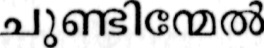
ചുണ്ടിന്മേല്‍
